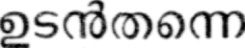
ഉടന്‍തന്നെ
